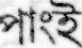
পাংই
